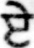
ਏ
